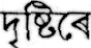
দৃষ্টিৰে
